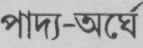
পাদ্য-অৰ্ঘে
